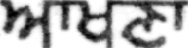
ਆਖਣਾ
